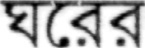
ঘরের
